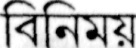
বিনিময়
